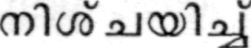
നിശ്ചയിച്ച്
